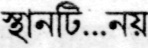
স্থানটি...নয়
